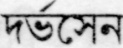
দর্ভসেন
